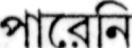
পারেনি
